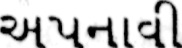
અપનાવી
